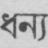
ধন্য
